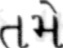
તમે
